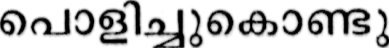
പൊളിച്ചുകൊണ്ടു
